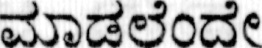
ಮಾಡಲೆಂದೇ
